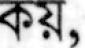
কয়,
